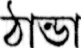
ঠান্ডা
